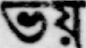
ভয়
